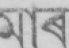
মাৰ
